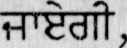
ਜਾਏਗੀ,
